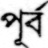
পূর্ব
